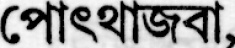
পোৎথাজবা,
